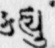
કહ્યું
